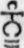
ਨੂੰ
